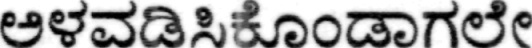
ಅಳವಡಿಸಿಕೊಂಡಾಗಲೇ
